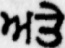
ਅਤੇ
